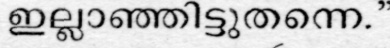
ഇല്ലാഞ്ഞിട്ടുതന്നെ.''
